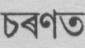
চৰণত
